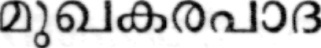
മുഖകരപാദ
